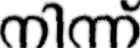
നിന്ന്
